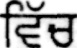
ਵਿੱਚ
